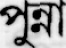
পুন্না
